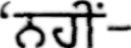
'ਨਹੀਂ-
